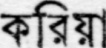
করিয়া
